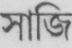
সাজি
